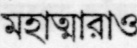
মহাত্মারাও
